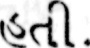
હતી.
